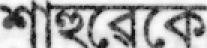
শাহুৱেকে
